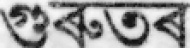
গুৰুতৰ
